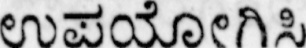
ಉಪಯೋಗಿಸಿ
